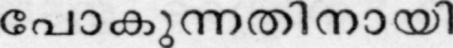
പോകുന്നതിനായി
